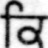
ਕਿ
